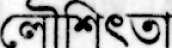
লৌশিৎতা
